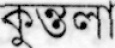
কুন্তলা
